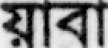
য়াবা
